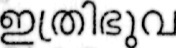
ഇത്രിഭൂവ
